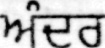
ਅੰਦਰ
